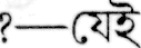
?-যেই
